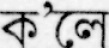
ক'লে
